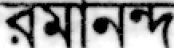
রমানন্দ
